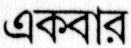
একবার
